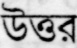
উত্তর
